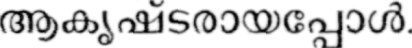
ആകൃഷ്ടരായപ്പോള്‍.
